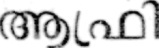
ആഫ്രി
